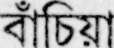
বাঁচিয়া
